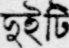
দুইটি
